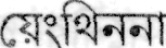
য়েংথিননা
